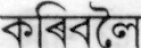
কৰিবলৈ
